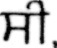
ਸੀ,
